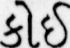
કોઈ
